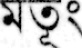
মতূং
